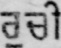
ਰੁਚੀ
